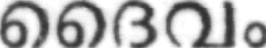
ദൈവം
